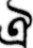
ঐ
